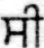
ਸੀ
